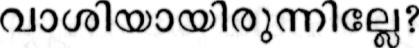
വാശിയായിരുന്നില്ലേ?
